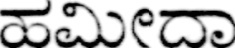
ಹಮೀದಾ
